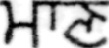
ਮਾਣ
